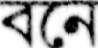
বনে
